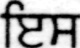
ਇਸ
